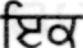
ਇਕ
